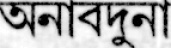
অনাবদুনা
